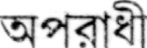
অপরাধী
